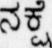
ನಕ್ಷೆ
